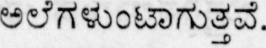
ಅಲೆಗಳುಂಟಾಗುತ್ತವೆ.
